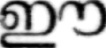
ഈ
